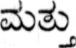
ಮತ್ತು
